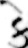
કે
